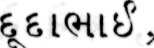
દૂદાભાઈ,
